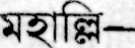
মহাল্লি-
